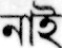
নাই
